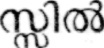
സ്സില്‍
